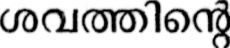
ശവത്തിന്റെ
